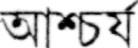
আশ্চর্য
